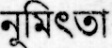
নুমিৎতা
